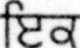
ਇਕ
